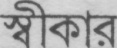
স্বীকার
